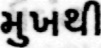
મુખથી
